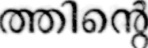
ത്തിന്റെ
